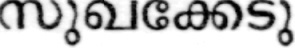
സുഖക്കേടു
